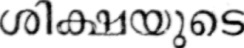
ശിക്ഷയുടെ
